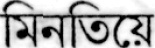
মিনতিয়ে
